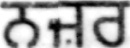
ਨਜ਼ਰ
